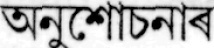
অনুশোচনাৰ
